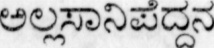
ಅಲ್ಲಸಾನಿಪೆದ್ದನ
